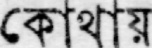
কোথায়
